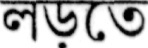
লড়তে
